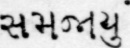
સમજાયું
